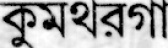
কুমথরগা
